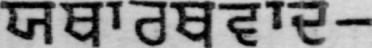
ਯਥਾਰਥਵਾਦ-
